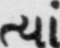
ત્યાં
